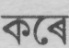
কৰে
